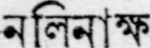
নলিনাক্ষ
